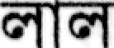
লাল
